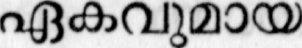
ഏകവുമായ
